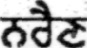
ਨਰੈਣ
